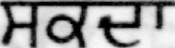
ਸਕਦਾ
